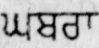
ਘਬਰਾ
